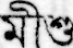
মীশু
